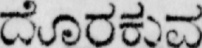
ದೊರಕುವ
